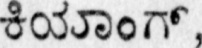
ಕಿಯಾಂಗ್,
